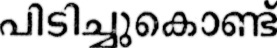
പിടിച്ചുകൊണ്ട്
